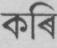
কৰি
